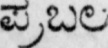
ಪ್ರಬಲ
